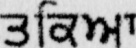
ਤਕਿਆ
